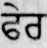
ਫੇਰ
